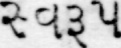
સ્વરૂપ
